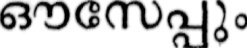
ഔസേപ്പും
